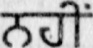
ਨਹੀਂ
